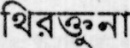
থিরক্তুনা
